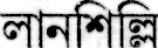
লানশিল্লি
